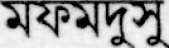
মফমদুসু
